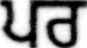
ਪਰ
